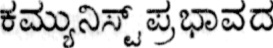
ಕಮ್ಯುನಿಸ್ಟ್ಪ್ರಭಾವದ
